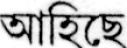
আহিছে
